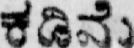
ಕಡಿಮೆ
